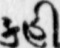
કહી
